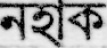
নহাক
